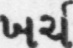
ખર્ચ
